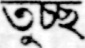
তুচ্ছ
